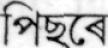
পিছৰে
